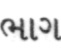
ભાગ
